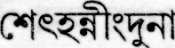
শেৎহন্নীংদুনা
